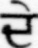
ਦੇ
